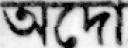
অদো
